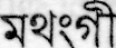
মথংগী
